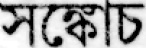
সঙ্কোচ
